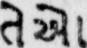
તેઓ
